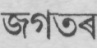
জগতৰ
